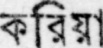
করিয়া
